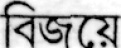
বিজয়ে
